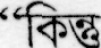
"কিন্তু
